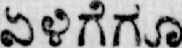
ಏಳಿಗೆಗೂ
